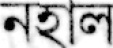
নহাল
